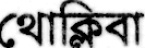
থোক্লিবা
